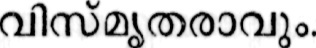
വിസ്മൃതരാവും.
